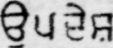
ਉਪਦੇਸ਼
